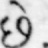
છે.
